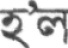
হ'ল
